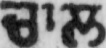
ਚਾਲ
